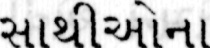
સાથીઓના
